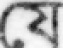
যে
